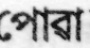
পোৱা
